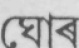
ঘোৰ
